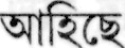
আহিছে
